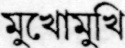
মুখোমুখি
